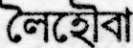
লৈহৌবা
